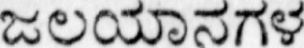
ಜಲಯಾನಗಳ
